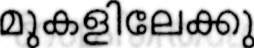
മുകളിലേക്കു
